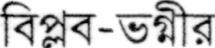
বিপ্লব-ভগ্নীর
